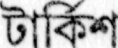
টার্কিশ
